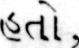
હતો,
